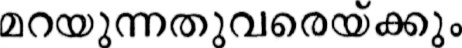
മറയുന്നതുവരെയ്ക്കും
